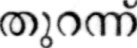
തുറന്ന്
